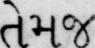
તેમજ
